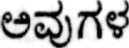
ಅವುಗಳ
